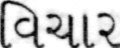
વિચાર
